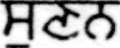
ਸੁਣਨ
